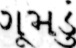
ગૂમડું
